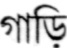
গাড়ি
